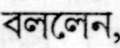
বললেন,
